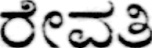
ರೇವತಿ
